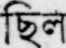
ছিল
